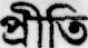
প্রীতি
